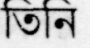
তিনি
